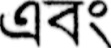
এবং
